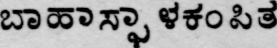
ಬಾಹಾಸ್ಫಾಳಕಂಪಿತ
